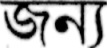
জন্য
